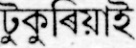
টুকুৰিয়াই
